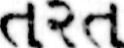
તરત
